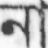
না
